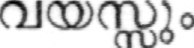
വയസ്സും
